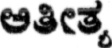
ಅತೀತ್ಯ
